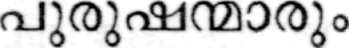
പുരുഷന്മാരും
